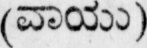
(ವಾಯು)
